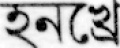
হনখ্রে
